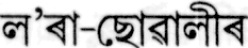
ল'ৰা-ছোৱালীৰ
